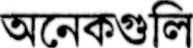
অনেকগুলি
